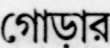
গোড়ার
